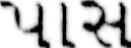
પાસ
